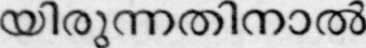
യിരുന്നതിനാല്‍
